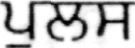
ਪੁਲਸ
